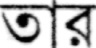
তার
